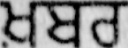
ਖ਼ਬਰ
